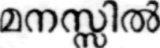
മനസ്സില്‍
